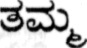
ತಮ್ಮ
